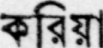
করিয়া
